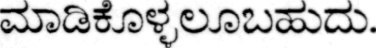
ಮಾಡಿಕೊಳ್ಳಲೂಬಹುದು.
